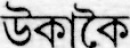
উকাকৈ
